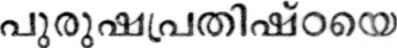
പുരുഷപ്രതിഷ്ഠയെ
